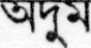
অদুম
